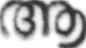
ആ
